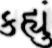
કહ્યું
